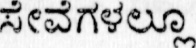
ಸೇವೆಗಳಲ್ಲೂ
